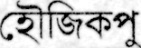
হৌজিকপু
